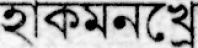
হাকমনখ্রে
